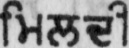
ਮਿਲਦੀ
